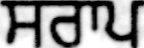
ਸਰਾਪ
